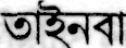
তাইনবা
